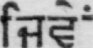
ਜਿਵੇਂ
